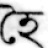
হৈ
